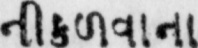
નીકળવાના
